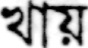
খায়
